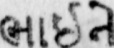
ભાઈને
